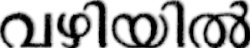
വഴിയില്‍
